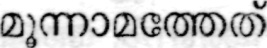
മൂന്നാമത്തേത്
